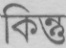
কিন্তু
